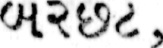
બરછટ,
